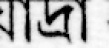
য়াদ্রা
